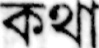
কথা
